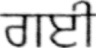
ਗਈ
